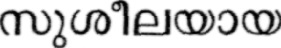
സുശീലയായ
